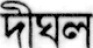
দীঘল
